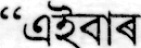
"এইবাৰ
